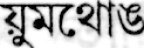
য়ুমথোঙ
